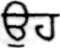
ਉਹ
